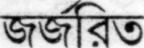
জর্জরিত
